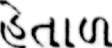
હેતાળ
